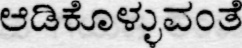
ಆಡಿಕೊಳ್ಳುವಂತೆ
